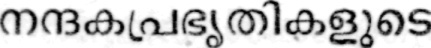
നന്ദകപ്രഭൃതികളുടെ
